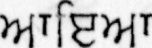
ਆਇਆ
